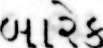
બારેક
